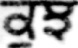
ਕੁਝ
